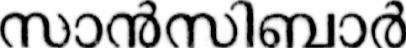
സാന്‍സിബാര്‍
